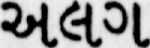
અલગ
